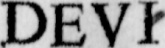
DEVI
